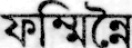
ফম্মিন্নৈ
